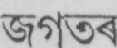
জগতৰ
